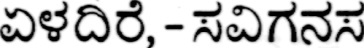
ಏಳದಿರೆ-ಸವಿಗನಸ
